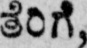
ತೆರಿಗೆ,
